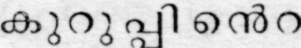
കുറുപ്പിന്റെ
